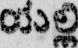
ಯಲ್ಲಿ
